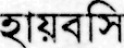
হায়বসি
